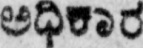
ಅಧಿಕಾರ
